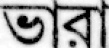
ভারা
